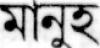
মানুহ
